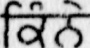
ਕਿੰਨੇ
